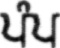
ਪੰਪ
